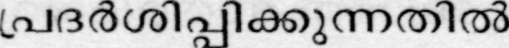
പ്രദര്‍ശിപ്പിക്കുന്നതില്‍
